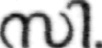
സി.
